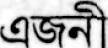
এজনী
